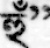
হুঁ”
